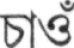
চাওঁ
